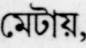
মেটায়,
